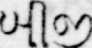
બીજી
